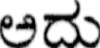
ಅದು
